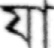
যা
